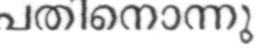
പതിനൊന്നു
